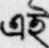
এই
